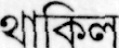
থাকিল
